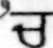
'ਚ
